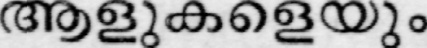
ആളുകളെയും
